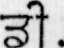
ਡੀ.
